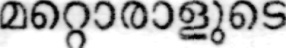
മറ്റൊരാളുടെ
